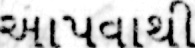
આપવાથી
